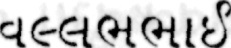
વલ્લભભાઈ
